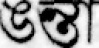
ঙন্তা
